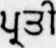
ਪ੍ਰਤੀ
